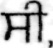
ਸੀ,
